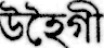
উহৈগী
